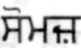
ਸੋਮਜ਼
